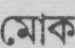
মোক
